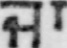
ਜਾ
